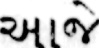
આજે
